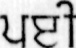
ਪਈ
